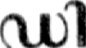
ഡി
